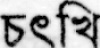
চৎখি
